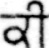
ਕੀ
